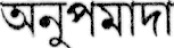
অনুপমাদা
